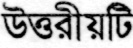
উত্তরীয়টি
